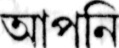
আপনি
